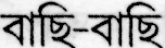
বাছি-বাছি
